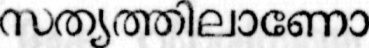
സത്യത്തിലാണോ
